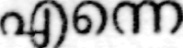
എന്നെ
